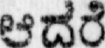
ಆದರೆ
